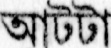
আটটা
